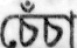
চেঁচা
